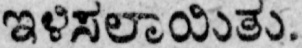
ಇಳಿಸಲಾಯಿತು.
